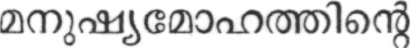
മനുഷ്യമോഹത്തിന്റെ
